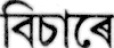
বিচাৰে
